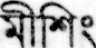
মীশিং
